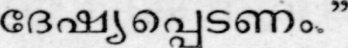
ദേഷ്യപ്പെടണം.”
